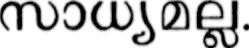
സാധ്യമല്ല.
